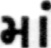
માં
